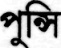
পুন্সি
